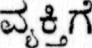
ವ್ಯಕ್ತಿಗೆ
